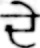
ਦੇ
